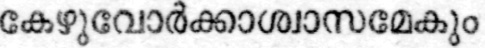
കേഴുവോര്‍ക്കാശ്വാസമേകും
